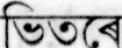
ভিতৰে
